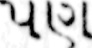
પણ
